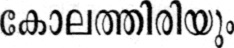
കോലത്തിരിയും
